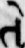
તે
